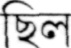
ছিল
